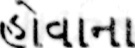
હોવાના
